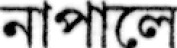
নাপালে
